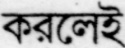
করলেই
